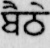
ਬੈਠੇ
